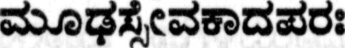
ಮೂಢಸ್ಸೇವಕಾದಪರಃ
